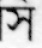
সি
